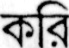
করি
